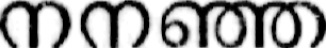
നനഞ്ഞ
